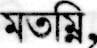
মতম্নি,
